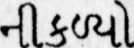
નીકળ્યો
